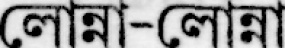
লোন্না-লোন্না
